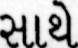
સાથે
